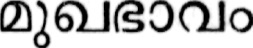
മുഖഭാവം
